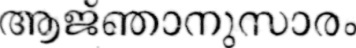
ആജ്ഞാനുസാരം
